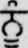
ਨੂੰ
